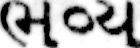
ભવ્ય
